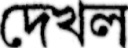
দেখল
